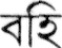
বহি
